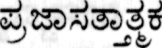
ಪ್ರಜಾಸತ್ತಾತ್ಮಕ
